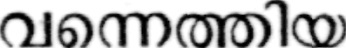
വന്നെത്തിയ
